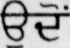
ਉਦੋਂ
